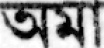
অমা
